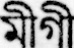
মীগী
